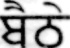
ਬੈਠੇ
